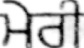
ਮੇਰੀ
